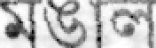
মঙাল
